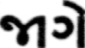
જાગે
